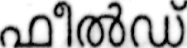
ഫീല്‍ഡ്
